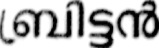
ബ്രിട്ടന്‍
